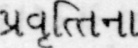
પ્રવૃત્તિના
